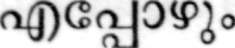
എപ്പോഴും
